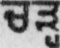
ਚੜ੍ਹ
